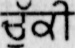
ਚੁੱਕੀ
